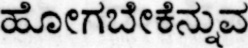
ಹೋಗಬೇಕೆನ್ನುವ
